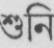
শুনি
